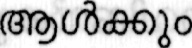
ആള്‍ക്കും
